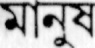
মানুষ
